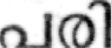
പരി
